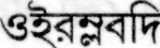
ওইরম্লবদি
